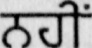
ਨਹੀਂ
